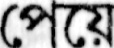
পেয়ে
